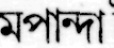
মপান্দা
